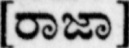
[ರಾಜಾ]
